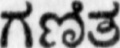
ಗಣಿತ
